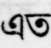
এত
